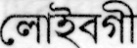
লোইবগী
